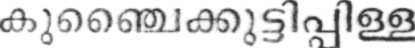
കുഞ്ചൈക്കുട്ടിപ്പിള്ള
